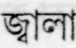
জ্বালা
